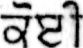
ਕੋਈ
